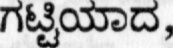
ಗಟ್ಟಿಯಾದ,
